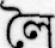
লৈ
